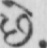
છે.
